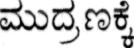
ಮುದ್ರಣಕ್ಕೆ
